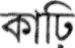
কাঢ়ি
